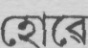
হোৱে
